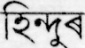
হিন্দুৰ
